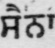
ਸੈਨਾ
